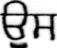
ਉਸ
